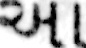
આ
